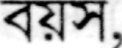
বয়স,
